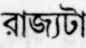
রাজ্যটা
